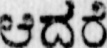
ಆದರೆ
